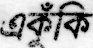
একুঁকি
